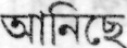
আনিছে
